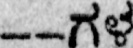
--ಗಳ
